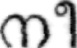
നീ
